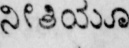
ನೀತಿಯೂ
